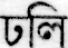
ঢলি
